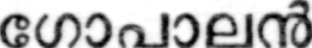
ഗോപാലന്‍
